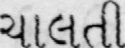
ચાલતી
